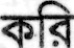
করি
